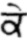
ਕੇ
